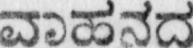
ವಾಹನದ
